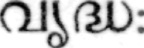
വൃദ്ധ:
